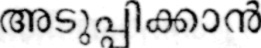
അടുപ്പിക്കാന്‍
